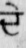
ਦੇ
